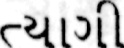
ત્યાગી
